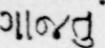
ગાજતું
